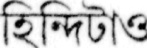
হিন্দিটাও
